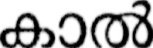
കാല്‍
